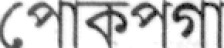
পোকপগা
